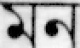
মন
